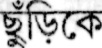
ছুঁড়িকে
